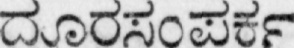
ದೂರಸಂಪರ್ಕ
